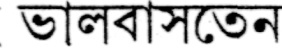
ভালবাসতেন
